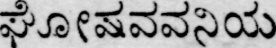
ಘೋಷವವನಿಯ
